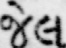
જેલ
